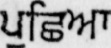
ਪੁਛਿਆ
